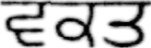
ਵਕਤ
